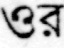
ওর
